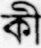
কী
